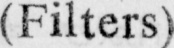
(Filters)
